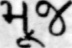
મૂજ
